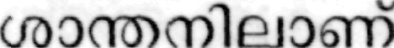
ശാന്തനിലാണ്
